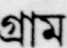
গ্রাম
